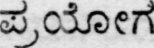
ಪ್ರಯೋಗ
